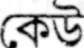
কেউ
